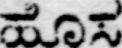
ಹೊಸ
